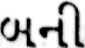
બની
